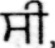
ਸੀ,
